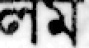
লম
